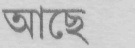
আছে
